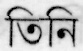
তিনি
